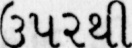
ઉપરથી
